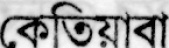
কেতিয়াবা
